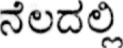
ನೆಲದಲ್ಲಿ
